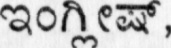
ಇಂಗ್ಲೀಷ್,
